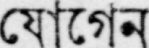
যোগেন
